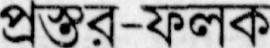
প্রস্তর-ফলক
